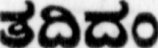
ತದಿದಂ
